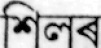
শিলৰ
